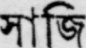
সাজি
